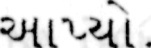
આપ્યો.
